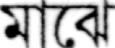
মাঝে
